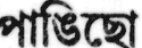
পাঙিছো
